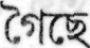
গৈছে
